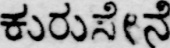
ಕುರುಸೇನೆ
